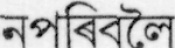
নপৰিবলৈ
